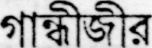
গান্ধীজীর
